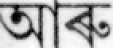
আৰু
